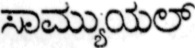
ಸಾಮ್ಯುಯಲ್
